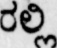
ರಲ್ಲಿ
